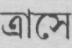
ত্রাসে
